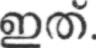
ഇത്.
